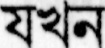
যখন
